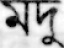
মদু
